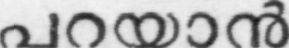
പറയാന്‍
